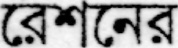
রেশনের
